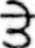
ਤੇ
